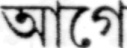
আগে
